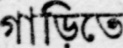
গাড়িতে
